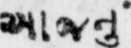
આજનું
